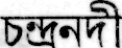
চন্দ্রনদী
